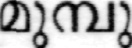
മുമ്പു
